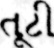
તૂટી
